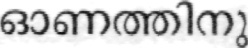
ഓണത്തിനു
